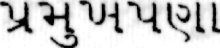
પ્રમુખપણા
